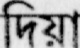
দিয়া
